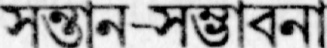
সন্তান-সম্ভাবনা
